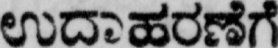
ಉದಾಹರಣೆಗೆ
